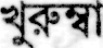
খুরুম্বা
